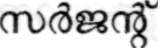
സര്‍ജന്റ്
